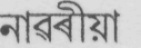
নাৱৰীয়া
